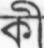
কী
